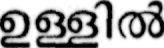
ഉള്ളില്‍
